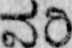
ವರಿ
